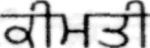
ਕੀਮਤੀ
